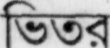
ভিতর
